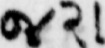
જરા
